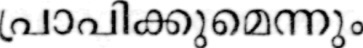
പ്രാപിക്കുമെന്നും
